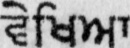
ਵੇਖਿਆ
